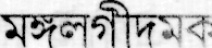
মঙ্গলগীদমক
